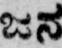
ಜನ
